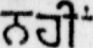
ਨਹੀਂ
